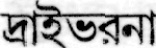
দ্রাইভরনা
